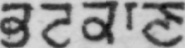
ਭਟਕਾਣ
